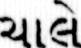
ચાલે
